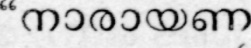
"നാരായണ
